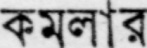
কমলার
